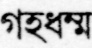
গহধম্ম
